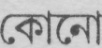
কোনো
